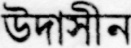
উদাসীন
